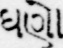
ઘણો
